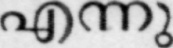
എന്നു
